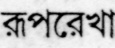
রূপরেখা
